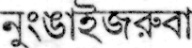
নুংঙাইজরুবা
